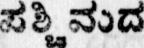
ಪಶ್ಚಿಮದ
